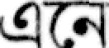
এনে
